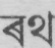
ৰথ
